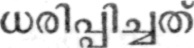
ധരിപ്പിച്ചത്
